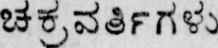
ಚಕ್ರವರ್ತಿಗಳು
